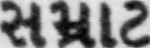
સમ્રાટ
